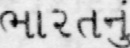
ભારતનું
